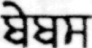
ਬੇਬਸ
